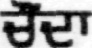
ਚੋਂਦਾ
